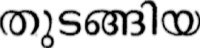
തുടങ്ങിയ
